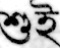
শুই
